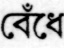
বেঁধে
